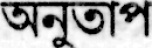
অনুতাপ
